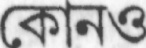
কোনও
